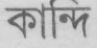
কান্দি
